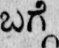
ಬಗ್ಗೆ
